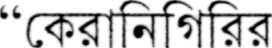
“কেরানিগিরির
